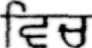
ਵਿਚ
